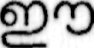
ഈ
